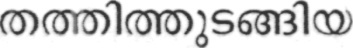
തത്തിത്തുടങ്ങിയ
